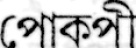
পোকপী
